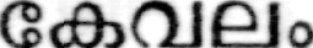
കേവലം
